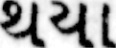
થયા
